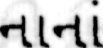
નાનાં
